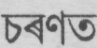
চৰণত
